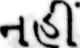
નહીં
